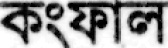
কংফাল
